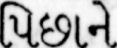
પિછાને
